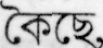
কৈছে,
